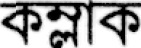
কম্লাক
